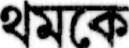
থমকে
